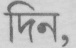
দিন,
